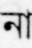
না
